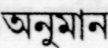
অনুমান
